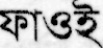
ফাওই
